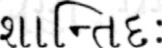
શાન્તિદઃ
